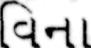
વિના
